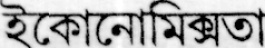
ইকোনিমিক্সতা
